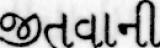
જીતવાની
